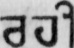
ਰਹੀ
